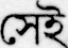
সেই
